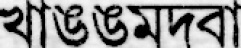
খাঙঙমদবা
